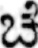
ಚೆ
